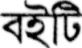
বইটি
